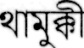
থামুক্কী
